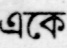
একে
